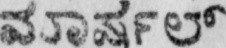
ಮಾರ್ಷಲ್
